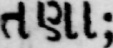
તણા;
